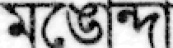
মঙোন্দা
